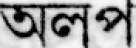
অলপ
